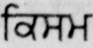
ਕਿਸਮ
